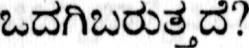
ಒದಗಿಬರುತ್ತದೆ?
